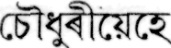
চৌধুৰীয়েহে
